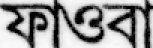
ফাওবা
